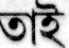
তাই
